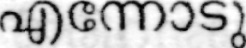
എന്നോടു
